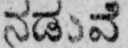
ನಡುವೆ
